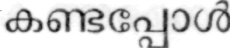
കണ്ടപ്പോള്‍
